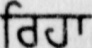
ਰਿਹਾ
